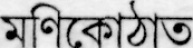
মণিকোঠাত
